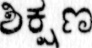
ಶಿಕ್ಷಣ
